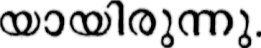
യായിരുന്നു.
